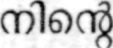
നിന്റെ
